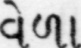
વેળા
